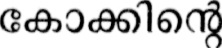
കോക്കിന്റെ
